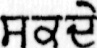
ਸਕਦੇ
